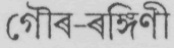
গৌৰ-ৰঙ্গিণী
